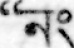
“নং
